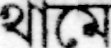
থামে
